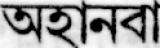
অহানবা
